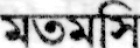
মতমসি
